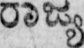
ರಾಜ್ಯ
